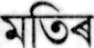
মতিৰ
